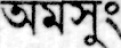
অমসুং
